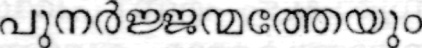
പുനര്‍ജ്ജന്മത്തേയും
